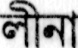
লীনা
